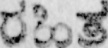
ರಹಿತ
